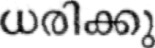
ധരിക്കു
